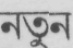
নতুন
